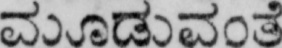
ಮೂಡುವಂತೆ
